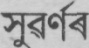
সুৱৰ্ণৰ
